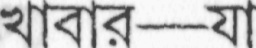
খাবার–যা
